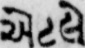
એટલે
